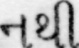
નથી
